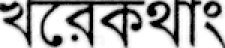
খরেকথাং
